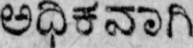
ಅಧಿಕವಾಗಿ
